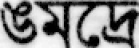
ঙমদ্রে
